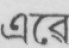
এৱে
